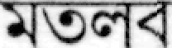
মতলব
